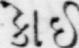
કોઈ
